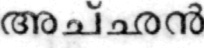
അച്ഛന്‍
